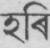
হৰি
